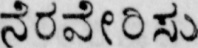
ನೆರವೇರಿಸು
